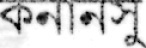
কনানসু
